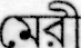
মেরী
